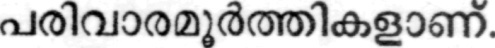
പരിവാരമൂര്‍ത്തികളാണ്.
